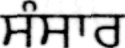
ਸੰਸਾਰ
